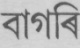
বাগৰি
